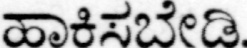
ಹಾಕಿಸಬೇಡಿ.
